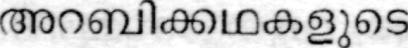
അറബിക്കഥകളുടെ
